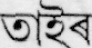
তাইৰ
